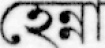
হেন্না
